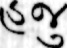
હજુ
